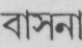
বাসনা
